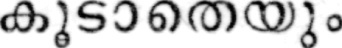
കൂടാതെയും
